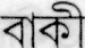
বাকী
